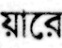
য়ারে
